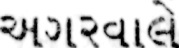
અગરવાલે
